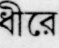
ধীরে
